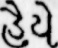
હૈયે
